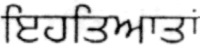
ਇਹਤਿਆਤਾਂ
